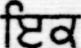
ਇਕ
